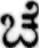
ಚೆ
